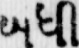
બધી
